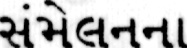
સંમેલનના
